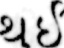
થઈ
